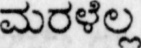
ಮರಳೆಲ್ಲ
